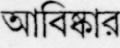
আবিষ্কার
